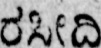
ರಸೀದಿ
